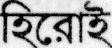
হিরোই
